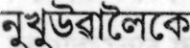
নুখুউৱালৈকে
